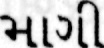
માગી
